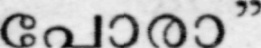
പോരാ"
